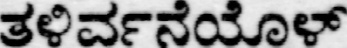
ತಳಿರ್ವನೆಯೊಳ್
